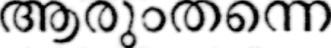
ആരുംതന്നെ
